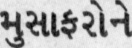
મુસાફરોને
